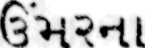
ઉંમરના
